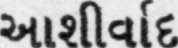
આશીર્વાદ
